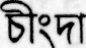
চীংদা
